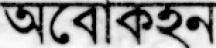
অবোকহন
